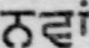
ਨਵਾਂ
